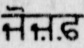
ਜੋਜ਼ਫ਼
